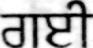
ਗਈ
